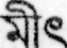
মীৎ
